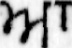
ਆ
